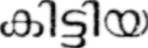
കിട്ടിയ
